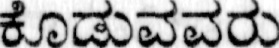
ಕೊಡುವವರು
